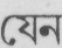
যেন
